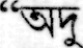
“অদু
